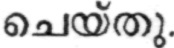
ചെയ്തു.
